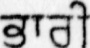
ਭਾਰੀ
